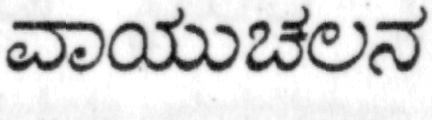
ವಾಯುಬೆಲನ
